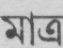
মাত্ৰ
